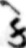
કે
